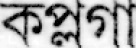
কপ্লগা
